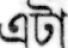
এটা
